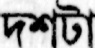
দশটা
